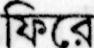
ফিরে
